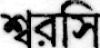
শ্বরসি
